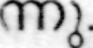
ന്നു.
